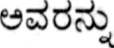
ಅವರನ್ನು
